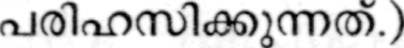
പരിഹസിക്കുന്നത്.)
